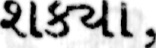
શક્યા,
